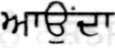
ਆਉਂਦਾ
